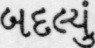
બદલ્યું
